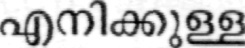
എനിക്കുള്ള
